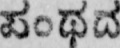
ಪಂಥದ
